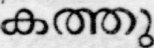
കത്തു
